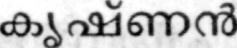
കൃഷ്ണന്‍
